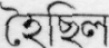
হৈছিল
